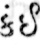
કંઈ
